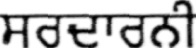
ਸਰਦਾਰਨੀ
